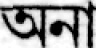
অনা
